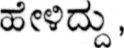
ಹೇಳಿದ್ದು,
